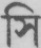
সি
